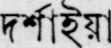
দর্শাইয়া
